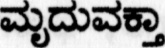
ಮೃದುವಕ್ತಾ
